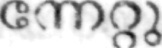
ന്നേറ്റു
